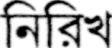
নিরিখ
